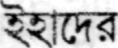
ইহাদের
